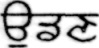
ਉਡਣ
